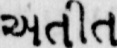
અતીત
